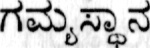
ಗಮ್ಯಸ್ಥಾನ
